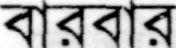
বারবার
